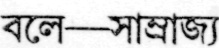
বলে–সাম্রাজ্য
